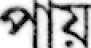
পায়
